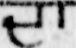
ਦਾ
